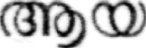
ആയ
